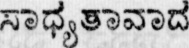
ಸಾಧ್ಯತಾವಾದ
